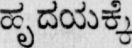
ಹೃದಯಕ್ಕೆ
